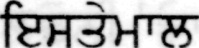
ਇਸਤੇਮਾਲ
